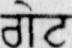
ਗੇਟ
